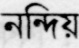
নন্দিয়
